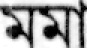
মমা
